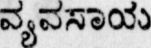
ವ್ಯವಸಾಯ
